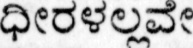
ಧೀರಳಲ್ಲವೇ
